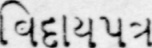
વિદાયપત્ર
